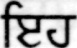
ਇਹ
